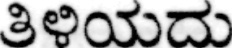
ತಿಳಿಯದು
